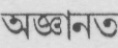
অজ্ঞানত
